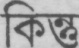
কিন্তু
